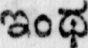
ಇಂಥ
